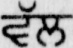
ਵੱਲ
